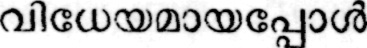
വിധേയമായപ്പോള്‍
